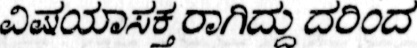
ವಿಷಯಾಸಕ್ತರಾಗಿದ್ದುದರಿಂದ
